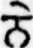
ਨੇ
